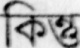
কিন্তু
